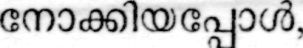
നോക്കിയപ്പോള്‍,
